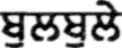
ਬੁਲਬੁਲੇ
